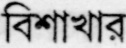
বিশাখার
